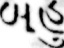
બહુ
